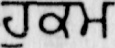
ਹੁਕਮ
